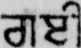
ਗਈ
